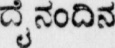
ದೈನಂದಿನ
